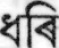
ধৰি
